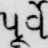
પૂર્વે
